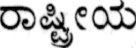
ರಾಷ್ಟ್ರೀಯ
